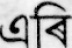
এৰি
